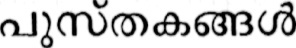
പുസ്തകങ്ങള്‍
